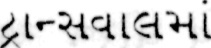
ટ્રાન્સવાલમાં
